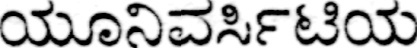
ಯೂನಿವರ್ಸಿಟಿಯ
